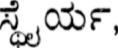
ಸ್ಥ್ರೈರ್ಯ,
